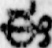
ಈ
